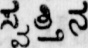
ಸ್ವತ್ತಿನ
